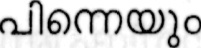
പിന്നെയും
